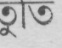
তুতি
